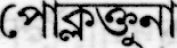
পোক্লক্তুনা
